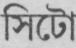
সিটো
